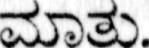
ಮಾತು.
